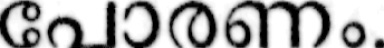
പോരണം.
